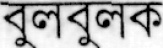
বুলবুলক
